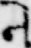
ને
